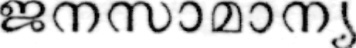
ജനസാമാന്യ
